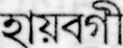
হায়বগী
